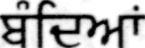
ਬੰਦਿਆਂ
